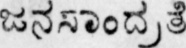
ಜನಸಾಂದ್ರತೆ
